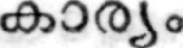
കാര്യം
